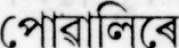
পোৱালিৰে
